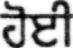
ਹੋਈ
